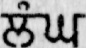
ਲੰਘ
